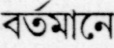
বর্তমানে
